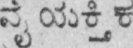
ವೈಯಕ್ತಿಕ
